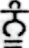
ਨੂੰ
